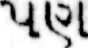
પણ
